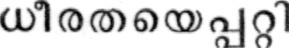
ധീരതയെപ്പറ്റി
